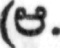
(ಆ.
